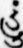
હું
